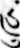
હું
